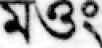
মওং
